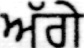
ਅੱਗੇ
